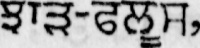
ਝਾੜ-ਫਲੂਸ,
